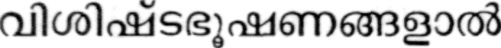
വിശിഷ്ടഭൂഷണങ്ങളാല്‍
